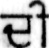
ਦੀ
